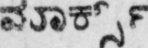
ಮಾರ್ಕ್ಸ್
